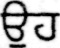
ਉਹ
